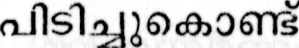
പിടിച്ചുകൊണ്ട്
